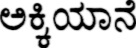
ಅಕ್ಕಿಯಾನೆ
